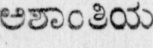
ಅಶಾಂತಿಯ
